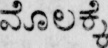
ಮೊಲಕ್ಕೆ
